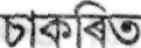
চাকৰিত
